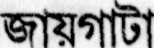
জায়গাটা
